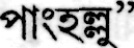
পাংহল্লু”
